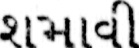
શમાવી
